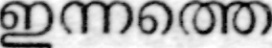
ഇന്നത്തെ
